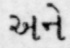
અને
